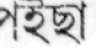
পইছা
